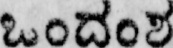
ಒಂದಂಶ
